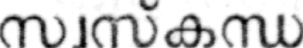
സ്വസ്കന്ധ
